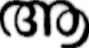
ആ
